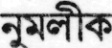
নুমলীক
